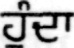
ਹੁੰਦਾ
